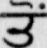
ਤੋਂ
